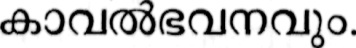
കാവല്‍ഭവനവും.
